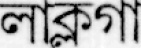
লাক্লগা
